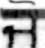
ਜੋ
